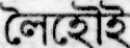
লৈহৌই
